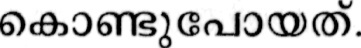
കൊണ്ടുപോയത്.
